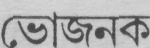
ভোজনক
